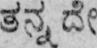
ತನ್ನದೇ
